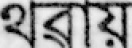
থৱায়
